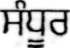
ਸੰਧੂਰ
